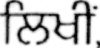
ਲਿਖੀਂ,
